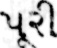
પૂરી
